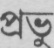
প্ৰভু
